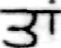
ਤਾਂ
